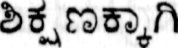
ಶಿಕ್ಷಣಕ್ಕಾಗಿ
